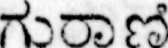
ಗುರಾಣಿ
